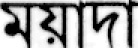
ময়াদা
